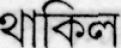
থাকিল
